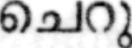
ചെറു
